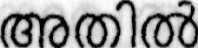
അതില്‍
